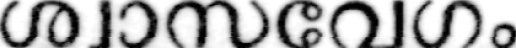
ശ്വാസവേഗം
